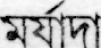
মর্যাদা
